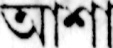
আশা
